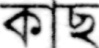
কাছ
